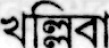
খল্লিবা
